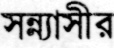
সন্ন্যাসীর
